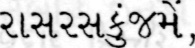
રાસરસકુંજમેં,
